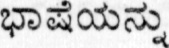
ಭಾಷೆಯನ್ನು
